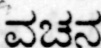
ವಚನ
